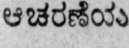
ಅಚರಣೆಯ
